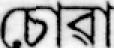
চোৱা
